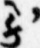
કે'
